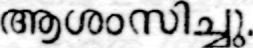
ആശംസിച്ചു.
